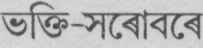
ভক্তি-সৰোবৰে
